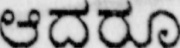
ಆದರೂ
